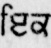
ਇਕ
